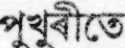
পুখুৰীতে
